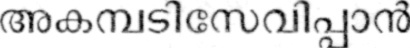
അകമ്പടിസേവിപ്പാന്‍
